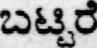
ಬಟ್ಟಿರೆ
